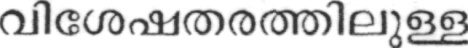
വിശേഷതരത്തിലുള്ള
